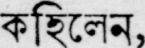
কহিলেন,
